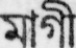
মাগী
